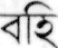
বহি
